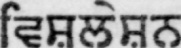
ਵਿਸ਼ਲੇਸ਼ਨ
